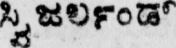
ಸ್ವಿಜರ್ಲಂಡ್
